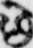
છે
